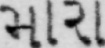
મારા
